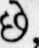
છે,
